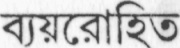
ব্যয়রোহিত
